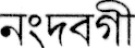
নংদবগী
